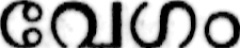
വേഗം
